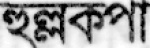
হুল্লকপা
